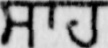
ਸਾਹ
